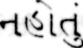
નહોતું
